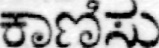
ಕಾಣಿಸು
